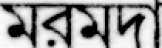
মরমদা
